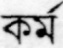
কর্ম
